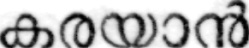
കരയാന്‍
